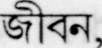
জীবন,
